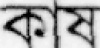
কাষ
